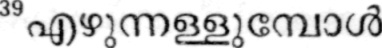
39എഴുന്നള്ളുമ്പോള്‍
